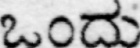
ಒಂದು
